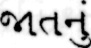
જાતનું
